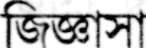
জিজ্ঞাসা
